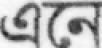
এনে
